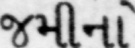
જમીનો
